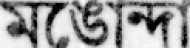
মঙোন্দা
